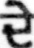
ਦੇ
